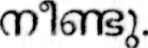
നീണ്ടു.
